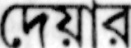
দেয়ার
